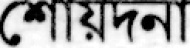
শোয়দনা
